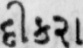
દીકરા
